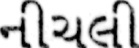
નીચલી
